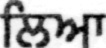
ਲਿਆ
